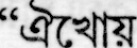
“ঐখোয়
